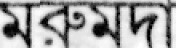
মরুমদা
